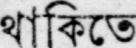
থাকিতে
